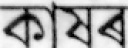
কাষৰ
